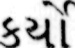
કર્યો
